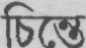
চিন্তে
